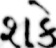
શકે
